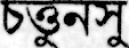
চত্তুনসু
